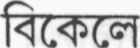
বিকেলে
